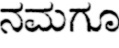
ನಮಗೂ
